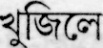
খুজিলে
